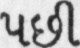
પછી
